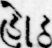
હોઠ
